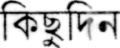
কিছুদিন
